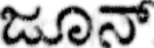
ಜೂನ್
